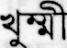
খুম্মী
